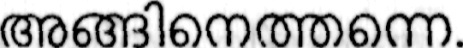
അങ്ങിനെത്തന്നെ.
